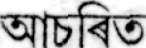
আচৰিত
